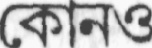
কোনও
